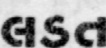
લડત
